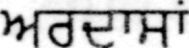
ਅਰਦਾਸਾਂ
